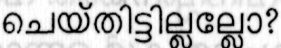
ചെയ്തിട്ടില്ലല്ലോ?
